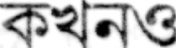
কখনও
